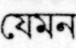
যেমন
